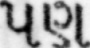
પણ
